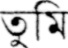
তুমি
